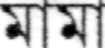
মামা
